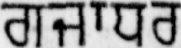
ਗਜਾਧਰ
